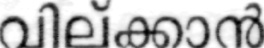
വില്ക്കാന്‍
